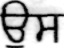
ਉਸ
